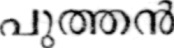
പുത്തന്‍
